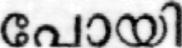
പോയി
